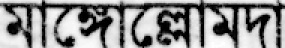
মাঙ্গোল্লোমদা
